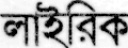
লাইরিক
